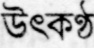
উত্কণ্ঠ
